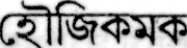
হৌজিকমক
